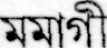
মমাগী
